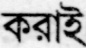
করাই
